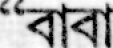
“বাবা
